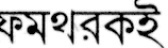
ফমথরকই
